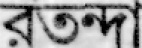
রতন্দা
